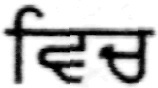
ਵਿਚ
